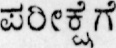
ಪರೀಕ್ಷೆಗೆ
